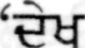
'ਦੇਖ
